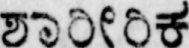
ಶಾರೀರಿಕ
